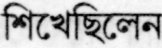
শিখেছিলেন
